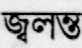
জ্বলন্ত
